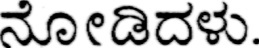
ನೋಡಿದಳು.
